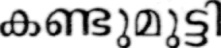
കണ്ടുമുട്ടി
